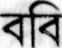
ববি
